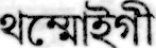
থম্মোইগী
